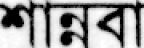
শান্নবা
